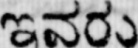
ಇವರು
